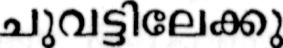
ചുവട്ടിലേക്കു
